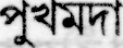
পুখমদা
